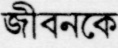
জীবনকে
